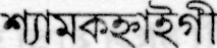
শ্যামকহ্ণাইগী
